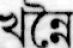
খন্নৈ
